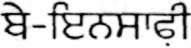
ਬੇ-ਇਨਸਾਫ਼ੀ
